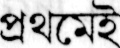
প্রথমেই
